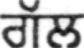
ਗੱਲ
